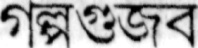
গল্পগুজব
